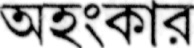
অহংকার
